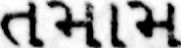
તમામ
